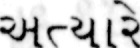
અત્યારે
